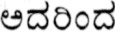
ಅದರಿಂದ
